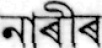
নাৰীৰ
